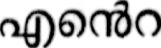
എന്റെ
